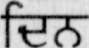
ਦਿਨ
